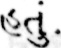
હતું.
